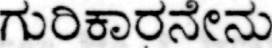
ಗುರಿಕಾರನೇನು
